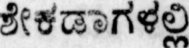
ಶೇಕಡಾಗಳಲ್ಲಿ
